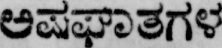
ಅಷಘಾತಗಳ
